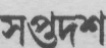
সপ্তদশ
